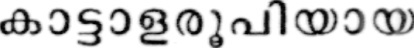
കാട്ടാളരൂപിയായ
